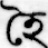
হৈ
